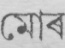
মোৰ
